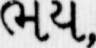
ભય,
